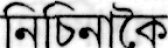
নিচিনাকৈ
